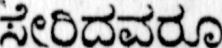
ಸೇರಿದವರೂ
